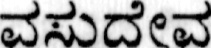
ವಸುದೇವ
